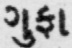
ગુફા
